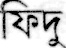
ফিদু
